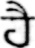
ਹੈ
